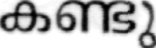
കണ്ടു
